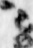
કે
